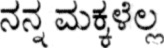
ನನ್ನಮಕ್ಕಳೆಲ್ಲ
